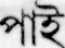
পাই
